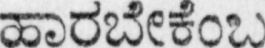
ಹಾರಬೇಕೆಂಬ
